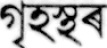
গৃহস্হৰ
